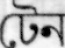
টেন
